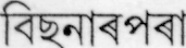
বিছনাৰপৰা
